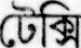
টেক্সি
